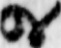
જ
